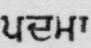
ਪਦਮਾ
